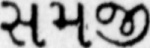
સમજી
